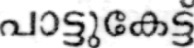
പാട്ടുകേട്ട്
